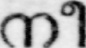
നീ
